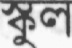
স্কুল
